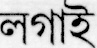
লগাই
